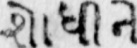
શોધીને
